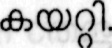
കയറ്റി.
